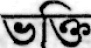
ভক্তি
